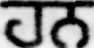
ਹਨ
